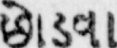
છોડવા
